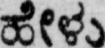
ಹೇಳು
